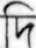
দি
